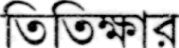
তিতিক্ষার
